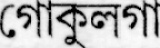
গোকুলগা
